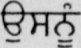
ਉਸਨੂੰ
